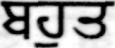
ਬਹੁਤ
